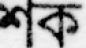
শক
